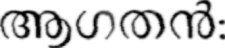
ആഗതന്‍:
